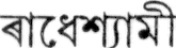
ৰাধেশ্যামী
